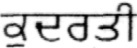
ਕੁਦਰਤੀ
